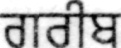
ਗਰੀਬ
